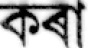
কৰা
